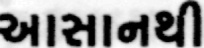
આસાનથી
